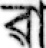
ৱা
